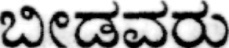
ಬೀಡವರು
